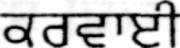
ਕਰਵਾਈ
